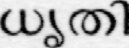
ധൃതി
